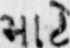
માટે
